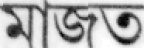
মাজত
